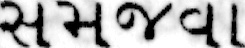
સમજવા
